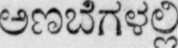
ಅಣಬೆಗಳಲ್ಲಿ
